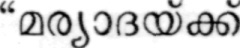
“മര്യാദയ്ക്ക്
